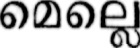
മെല്ലെ
